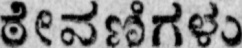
ಠೇವಣಿಗಳು
